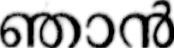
ഞാന്‍
